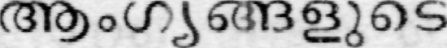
ആംഗ്യങ്ങളുടെ
